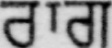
ਰਾਗ
